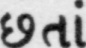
છતાં
